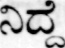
ನಿದ್ದೆ
